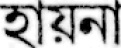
হায়না
